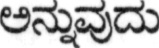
ಅನ್ನುವುದು
